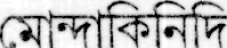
মোন্দাকিনিদি
